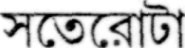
সতেরোটা
